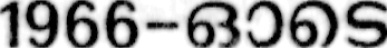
1966-ഓടെ
